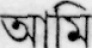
আমি
